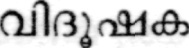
വിദൂഷക
